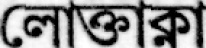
লোক্তাক্না
